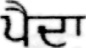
ਪੈਦਾ
